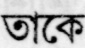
তাকে
